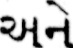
અને
